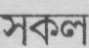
সকল
